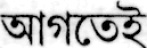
আগতেই
